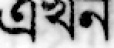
এখন
